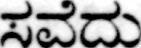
ಸವೆದು
